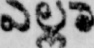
ಎಲ್ಲಾ
